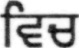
ਵਿਚ
